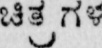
ಚಿತ್ರಗಳ
